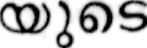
യുടെ
